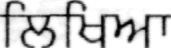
ਲਿਖਿਆ
